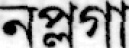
নপ্লগা
